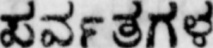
ಪರ್ವತಗಳ
